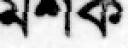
মশক
